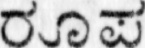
ರೂಪ
